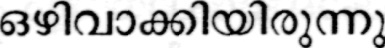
ഒഴിവാക്കിയിരുന്നു
